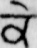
ਕੇ
